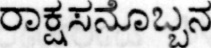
ರಾಕ್ಷಸನೊಬ್ಬನ
